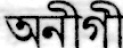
অনীগী
